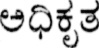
ಅಧಿಕೃತ
